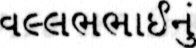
વલ્લભભાઈનું
